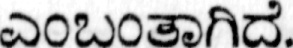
ಎಂಬಂತಾಗಿದೆ.
